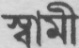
স্বামী
